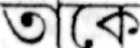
তাকে
